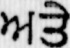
ਅਤੇ
